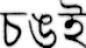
চঙই
